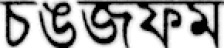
চঙজফম
